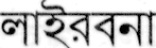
লাইরবনা
